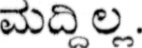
ಮದ್ದಿಲ್ಲ.
